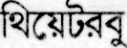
থিয়েটরবু
